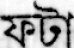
ফটা
